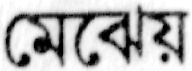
মেঝেয়
